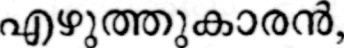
എഴുത്തുകാരന്‍,
